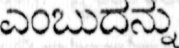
ಎಂಬುದನ್ನು
